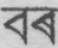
বৰ
